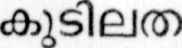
കുടിലത
